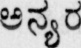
ಅನ್ಯರ
